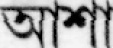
আশা
